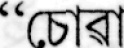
"চোৱা
